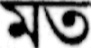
মত
